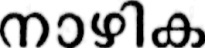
നാഴിക
